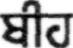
ਬੀਹ
